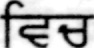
ਵਿਚ
